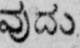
ವುದು
